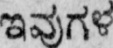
ಇವುಗಳ
